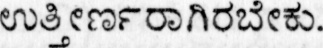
ಉತ್ತೀರ್ಣರಾಗಿರಬೇಕು.
